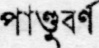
পাণ্ডুবর্ণ
